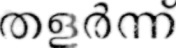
തളര്‍ന്ന്
